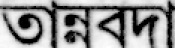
তান্নবদা
